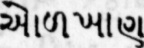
ઓળખાણ
